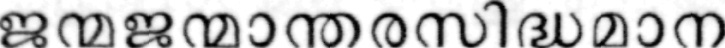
ജന്മജന്മാന്തരസിദ്ധമാന
